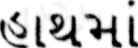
હાથમાં
